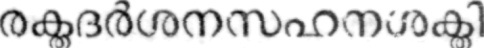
രക്തദര്‍ശനസഹനശക്തി
